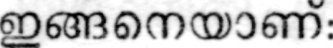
ഇങ്ങനെയാണ്:
